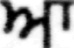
ਆ
